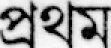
প্রথম
